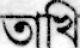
তাখি
